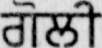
ਗੋਲੀ
